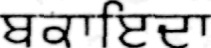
ਬਕਾਇਦਾ
